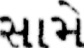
સામે
